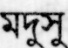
মদুসু
